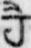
ਹੈ
